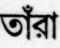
তাঁরা
